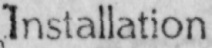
Installation
